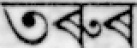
তৰুৰ
